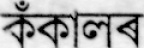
কঁকালৰ
